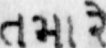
તમારે
